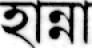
হান্না
